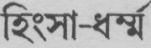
হিংসা-ধৰ্ম্ম
